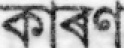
কাৰণ
